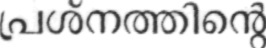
പ്രശ്നത്തിന്റെ
